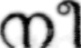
നീ
